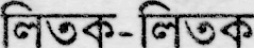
লিতক-লিতক
